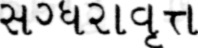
સગ્ધરાવૃત્ત
